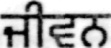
ਜੀਵਨ
